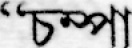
"চম্পা
